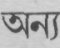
অন্য
